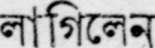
লাগিলেন
